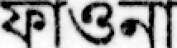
ফাওনা
